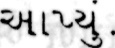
આપ્યું.
